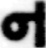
ન
